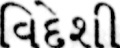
વિદેશી
